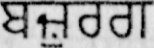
ਬਜ਼ੁਰਗ
